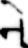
ને
